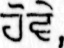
ਹੋਵੇ,
